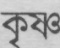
কৃষ্ণ
